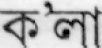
ক'লা
